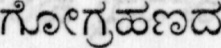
ಗೋಗ್ರಹಣದ
